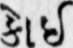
કોઈ
